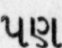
પણ
